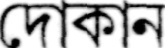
দোকান
